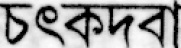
চৎকদবা
